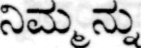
ನಿಮ್ಮನ್ನು
